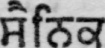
ਸੈਨਿਕ
